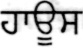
ਹਾਊਸ
